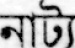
নাট্য
